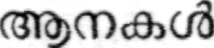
ആനകള്‍
